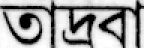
তাদ্রবা
